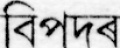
বিপদৰ
